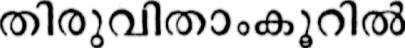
തിരുവിതാംകൂറില്‍
